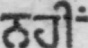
ਨਹੀਂ
